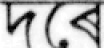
দৰে
